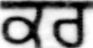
ਕਰ
